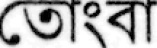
তোংবা
